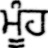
ਮੂੰਹ
